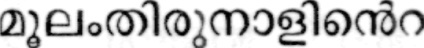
മൂലംതിരുനാളിന്റെ
